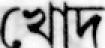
খোদ
